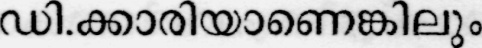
ഡി.ക്കാരിയാണെങ്കിലും
